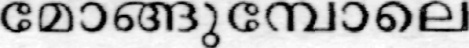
മോങ്ങുമ്പോലെ
